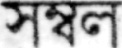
সম্বল
